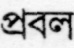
প্রবল
